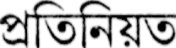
প্রতিনিয়ত
